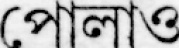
পোলাও
